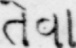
તેવા
